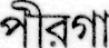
পীরগা
